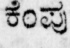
ಕೆಂಪು
